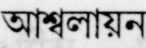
আশ্বলায়ন
